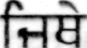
ਜਿਥੇ
